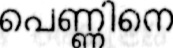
പെണ്ണിനെ
